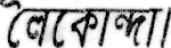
লৈকোন্দা।
